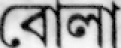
বোলা
